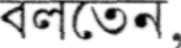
বলতেন,
